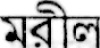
মরীল
